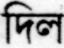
দিল
